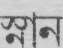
স্নান
